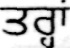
ਤਰ੍ਹਾਂ
